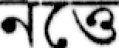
নত্তে
